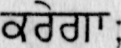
ਕਰੇਗਾ;
